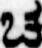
ಚ
